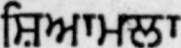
ਸ਼ਿਆਮਲਾ
